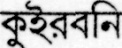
কুইরবনি
